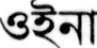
ওইনা
